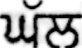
ਘੱਲ
